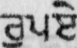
ਰੁਪਏ
